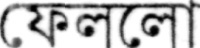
ফেললো
